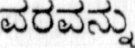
ವರವನ್ನು
